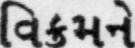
વિક્રમને
